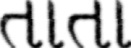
તાતા
